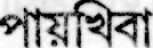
পায়খিবা
